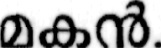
മകന്‍.
